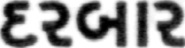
દરબાર
